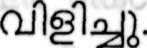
വിളിച്ചു.
